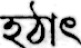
হঠাৎ
